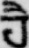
ਹੈ
